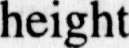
height
